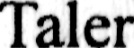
Taler
